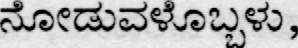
ನೋಡುವಳೊಬ್ಬಳು,
